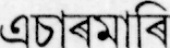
এচাৰমাৰি
